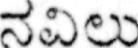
ನವಿಲು
